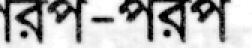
পরপ-পরপ
